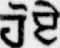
ਹੋਏ
